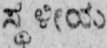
ಸ್ಥಳೀಯ
